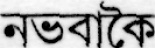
নভবাকৈ
